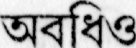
অবধিও
